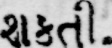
શકતી.
